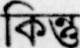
কিন্তু
